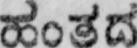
ಹಂತದ
